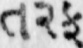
તરફ
